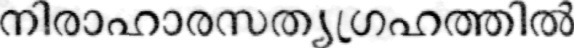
നിരാഹാരസത്യഗ്രഹത്തില്‍
